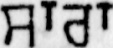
ਸਾਰਾ
